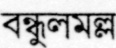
বন্ধুলমল্ল
